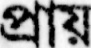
প্রায়
